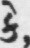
કે,
